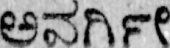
ಅವರ್ಗೀ
